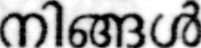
നിങ്ങള്‍
